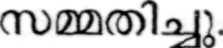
സമ്മതിച്ചു.
